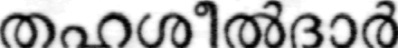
തഹശീല്‍ദാര്‍
